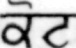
ਕੋਟ
